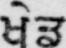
ਖੇਡ
